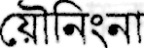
য়ৌনিংনা
